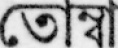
তোম্বা
